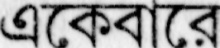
একেবারে
